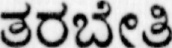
ತರಬೇತಿ
